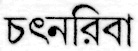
চৎনরিবা
